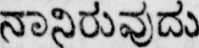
ನಾನಿರುವುದು
